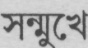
সন্মুখে
